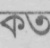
কত
